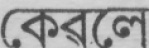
কেৱলে
